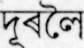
দূৰলৈ
